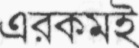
এরকমই
